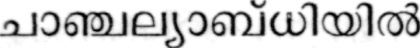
ചാഞ്ചല്യാബ്ധിയില്‍
